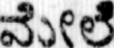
ಮೇಲೆ
